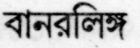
বানরলিঙ্গ
